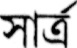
সার্ত্র
